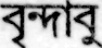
বৃন্দাবু
